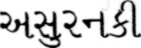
અસુરનકી
